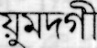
য়ুমদগী
